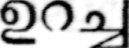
ഉറച്ച
